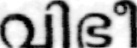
വിഭീ
